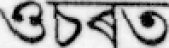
ওচৰত
